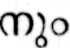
നും
